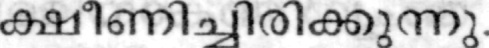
ക്ഷീണിച്ചിരിക്കുന്നു.
